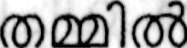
തമ്മില്‍
